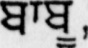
ਬਾਬੂ,
